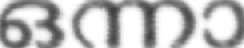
ഒന്നാ
